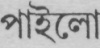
পাইলো
